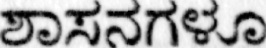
ಶಾಸನಗಳೂ
